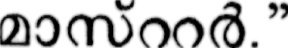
മാസ്ററര്‍.”
